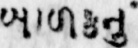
બાળકનું
